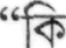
"কি
